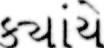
ક્યાંયે
